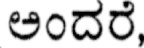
ಅಂದರೆ,
